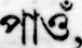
পাওঁ,
